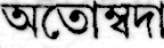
অতোম্বদা
